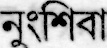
নুংশিবা
